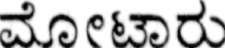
ಮೋಟಾರು
